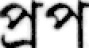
প্রপ
